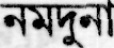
নমদুনা
